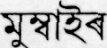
মুম্বাইৰ
